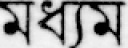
মধ্যম
